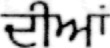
ਦੀਆਂ
